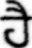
ਹੈ
